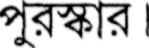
পুরস্কার।
